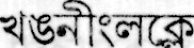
খঙনীংলক্লে
